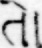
તો
